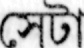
সেটা
